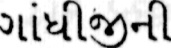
ગાંધીજીની
